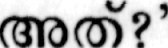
അത്?’
